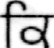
ਕਿ
